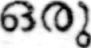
ഒരു
